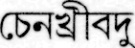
চেনখ্রীবদু
